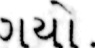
ગયો.
